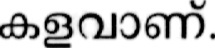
കളവാണ്.
